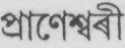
প্রাণেশ্বৰী
